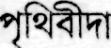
পৃথিবীদা
